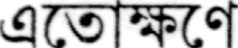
এতোক্ষণে
